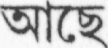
আছে
